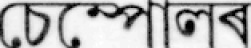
চেম্পোলৰ
